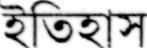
ইতিহাস
